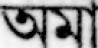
অমা
